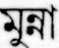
মুন্না
